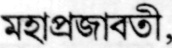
মহাপ্রজাবতী,
